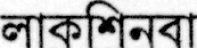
লাকশিনবা
